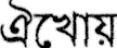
ঐখোয়
